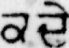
ਕਦੇ
